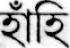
হাঁহি
